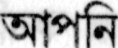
আপনি
